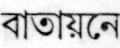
বাতায়নে
